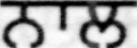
ਨਾਲ
